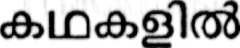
കഥകളില്‍
